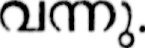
വന്നു.
